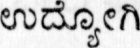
ಉದ್ಯೋಗಿ
